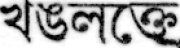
খঙলক্ত্রে
